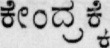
ಕೇಂದ್ರಕ್ಕೆ
